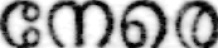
നേരെ
